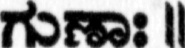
ಗುಣಾಃ||
